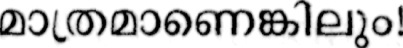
മാത്രമാണെങ്കിലും!
